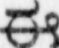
ಈ
